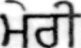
ਮੇਰੀ
